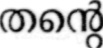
തന്റെ
